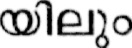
യിലും
